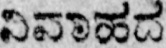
ವಿವಾಹದ
